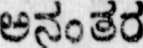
ಅನಂತರ
